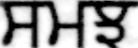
ਸਮਝ
